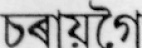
চৰায়গৈ
